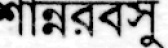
শান্নরবসু
